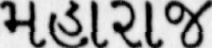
મહારાજ
